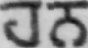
ਹਨ
